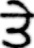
ਤੇ
